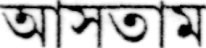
আসতাম
